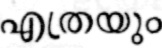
എത്രയും
